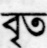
বৃত
